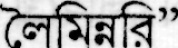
লৈমিন্নরি”
